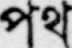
পথ
